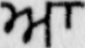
ਆ
